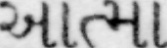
આત્મા
